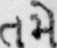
તમે
